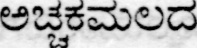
ಅಚ್ಚಕಮಲದ
